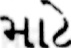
માટે
